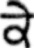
ਕੇ
